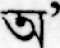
অ'
